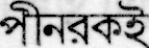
পীনরকই
